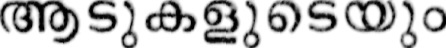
ആടുകളുടെയും
